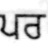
ਪਰ
